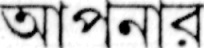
আপনার
